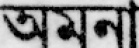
অমনা
